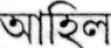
আহিল
